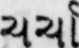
ચર્ચા
